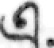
এ.
